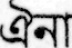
ঐনা
